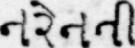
નરેનની
